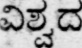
ವಿಶ್ಚದ
